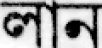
লান
